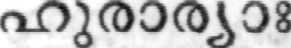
ഹുരാര്യാഃ
